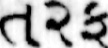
તરફ
